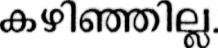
കഴിഞ്ഞില്ല.
